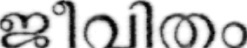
ജീവിതം
